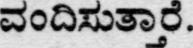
ವಂದಿಸುತ್ತಾರೆ.
